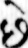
છે
